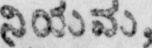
ನಿಯಮ,
